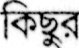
কিছুর
